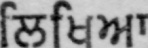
ਲਿਖਿਆ
